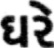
ઘરે
